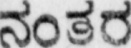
ನಂತರ
